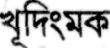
খূদিংমক
